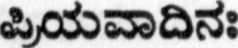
ಪ್ರಿಯವಾದಿನಃ
